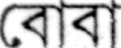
বোবা
